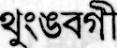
থুংঙবগী
